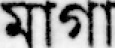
মাগা
